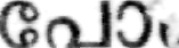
പോ
